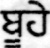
ਬੂਹੇ
